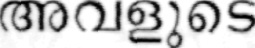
അവളുടെ
